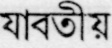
যাবতীয়
